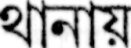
থানায়
